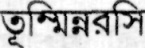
তূম্মিন্নরসি
